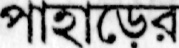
পাহাড়ের
